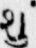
શું
